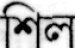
শিল
